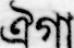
ঐগা
